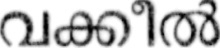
വക്കീല്‍
